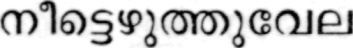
നീട്ടെഴുത്തുവേല
